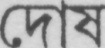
দোষ
